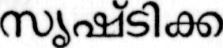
സൃഷ്ടിക്ക
